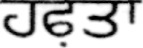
ਹਫ਼ਤਾ
